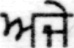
ਅਜੇ
